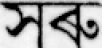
সৰু
